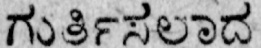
ಗುರ್ತಿಸಲಾದ
